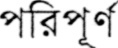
পরিপূর্ণ
